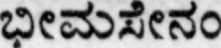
ಭೀಮಸೇನಂ
